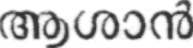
ആശാന്‍
